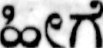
ಹೀಗೆ
